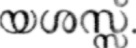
യശസ്സ്.
